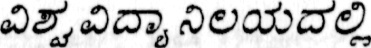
ವಿಶ್ವವಿದ್ಯಾನಿಲಯದಲ್ಲಿ
